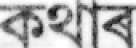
কথাৰ
